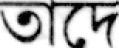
তাদে
